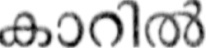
കാറില്‍
